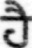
ਹੈ
